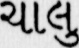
ચાલું
